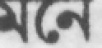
মনে
